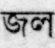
জল
